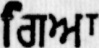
ਗਿਆ
